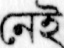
নেই
